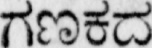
ಗಣಕದ
